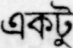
একটু
